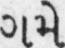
ગમે
